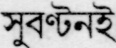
সুবন্টনই
